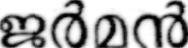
ജര്‍മന്‍
